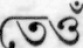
তেওঁ
